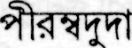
পীরম্বদুদা
